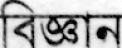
বিজ্ঞান
